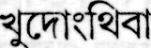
খুদোংথিবা
